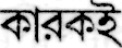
কারকই
